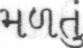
મળતું
